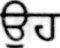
ਉਹ
